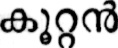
കൂറ്റന്‍
